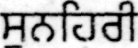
ਸੁਨਹਿਰੀ
